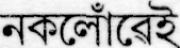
নকলোঁৱেই
